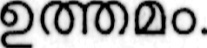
ഉത്തമം.
